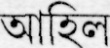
আহিল
